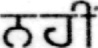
ਨਹੀਂ
